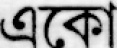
একো
